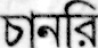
চানরি
